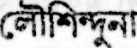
লৌশিন্দুনা
